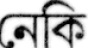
নেকি
